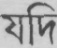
যদি
